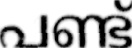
പണ്ട്
